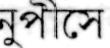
নুপীসে
